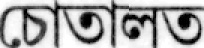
চোতালত
